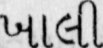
ખાલી
